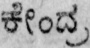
ಕೇಂದ್ರ
